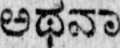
ಅಥವಾ
